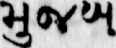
મુજબ
